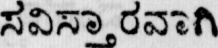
ಸವಿಸ್ತಾರವಾಗಿ
